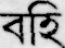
বহি
